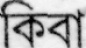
কিবা
